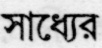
সাধ্যের
